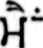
ਮੈਂ
